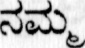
ನಮ್ಮ
